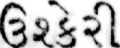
ઉશ્કેરી
